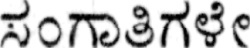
ಸಂಗಾತಿಗಳೇ
